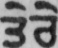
ਤੇਰੇ
